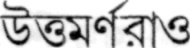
উত্তমর্ণরাও
